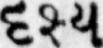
દશ્ય
